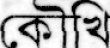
কৌখি
